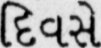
દિવસે
